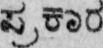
ಪ್ರಕಾರ
